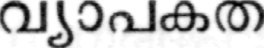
വ്യാപകത
